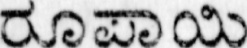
ರೂಪಾಯಿ
